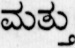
ಮತ್ತು
